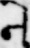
ને
